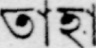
তাহা
